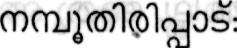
നമ്പൂതിരിപ്പാട്:
